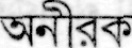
অনীরক
